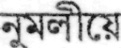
নুমলীয়ে
